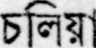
চলিয়া
